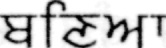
ਬਣਿਆ
